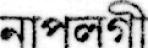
নাপলগী
